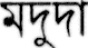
মদুদা
